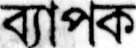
ব্যাপক
